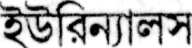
ইউরিন্যালস
